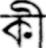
কী
